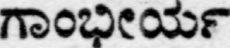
ಗಾಂಭೀರ್ಯ
